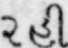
રહી
